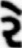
રે
